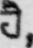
ਹੈ,
